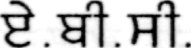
ਏ.ਬੀ.ਸੀ.
